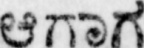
ಆಗಾಗ
